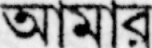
আমার
